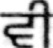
ਵੀ
